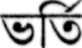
ভর্তি
